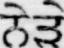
ਨੇੜੇ
